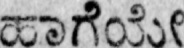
ಹಾಗೆಯೇ
